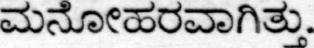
ಮನೋಹರವಾಗಿತ್ತು.
